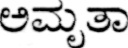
ಅಮೃತಾ
